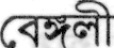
বেঙ্গলী
